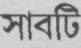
সাবটি
